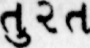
તુરત
